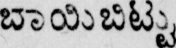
ಬಾಯಿಬಿಟ್ಟು
